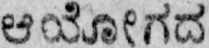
ಆಯೋಗದ
